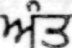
ਅੰਤ
